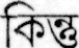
কিন্তু
